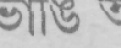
ভাঙি
